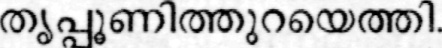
തൃപ്പൂണിത്തുറയെത്തി.
